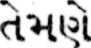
તેમણે
